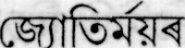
জ্যোতির্ময়ৰ
